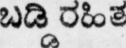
ಬಡ್ಡಿರಹಿತ
